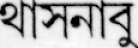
থাসনাবু
